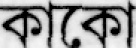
কাকো
